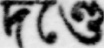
দণ্ডে
